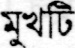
মুখটি
